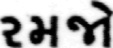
રમજો
